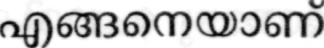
എങ്ങനെയാണ്
